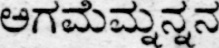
ಅಗಮೆಮ್ನನ್ನನ
